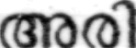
അരി
